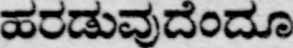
ಹರಡುವುದೆಂದೂ
